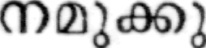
നമുക്കു
